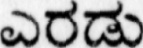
ಎರಡು
